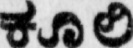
ಕೂಲಿ
